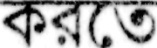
করতে
